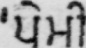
'ਪੇਮੀ
